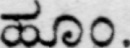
ಹೂಂ.
